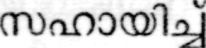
സഹായിച്ച്
